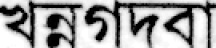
খন্নগদবা
